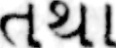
તથા
